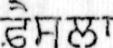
ਫ਼ੈਸਲਾ
